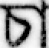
চা
